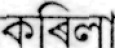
কৰিলা
